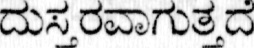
ದುಸ್ತರವಾಗುತ್ತದೆ
